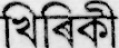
খিৰিকী
